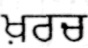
ਖ਼ਰਚ
